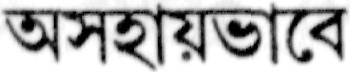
অসহায়ভাবে
